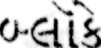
બ્લૉકે
